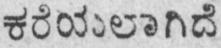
ಕರೆಯಲಾಗಿದೆ
